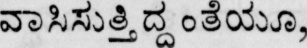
ವಾಸಿಸುತ್ತಿದ್ದಂತೆಯೂ,
